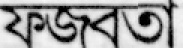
ফজবতা
